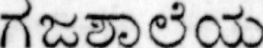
ಗಜಶಾಲೆಯ
